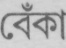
বেঁকা
